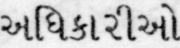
અધિકારીઓ
